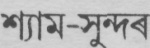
শ্যাম-সুন্দৰ
